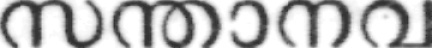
സന്താനവ
